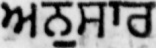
ਅਨੁਸਾਰ
